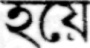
হয়ে
